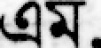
এম.
